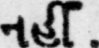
નહીં.
